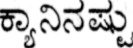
ಕ್ಯಾನಿನಷ್ಟು
